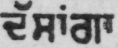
ਦੱਸਾਂਗਾ
